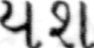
યશ
